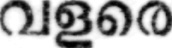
വളരെ
